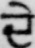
ਦੇ
